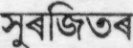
সুৰজিতৰ
